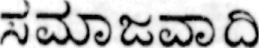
ಸಮಾಜವಾದಿ
